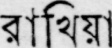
রাখিয়া
